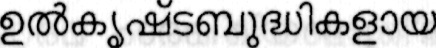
ഉല്‍കൃഷ്ടബുദ്ധികളായ
